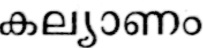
കല്യാണം
